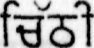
ਚਿੱਠੀ
